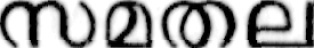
സമതല
